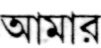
আমার
